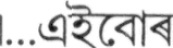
।...এইবোৰ
